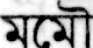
মমৌ
